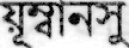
য়ূম্বানসু
